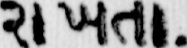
રાખતા.
